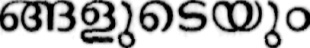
ങ്ങളുടെയും
